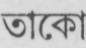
তাকো
